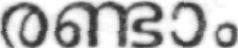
രണ്ടാം
